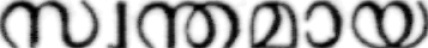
സ്വന്തമായ
